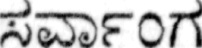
ಸರ್ವಾಂಗ
